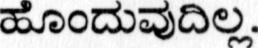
ಹೊಂದುವುದಿಲ್ಲ.
